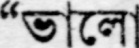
‘‘ভালো
